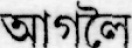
আগলৈ
